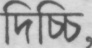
দিচ্চি,
